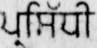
ਪ੍ਰਸਿੱਧੀ
